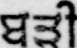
ਬੜੀ
